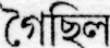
গৈছিল
